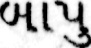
બાપુ
